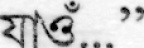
যাওঁ..."
